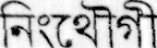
নিংথৌগী
